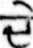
ਦੇ
